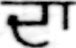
ਦਾ
